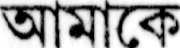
আমাকে
